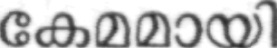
കേമമായി
